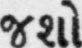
જશો
